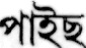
পাইছ
